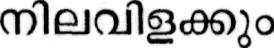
നിലവിളക്കും
